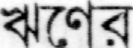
ঋণের
